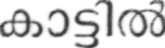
കാട്ടില്‍
